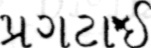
પ્રગટાઈ-વ્રજ
